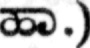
ಹಾ)
